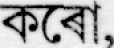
কৰো,
